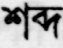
শব্দ
